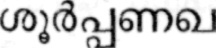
ശൂര്‍പ്പണഖ
